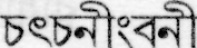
চৎচনীংবনী
